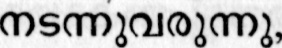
നടന്നുവരുന്നു.
